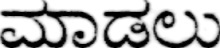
ಮಾಡಲು
